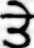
ਤੇ
